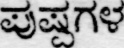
ಪುಷ್ಪಗಳ
